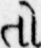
તો
